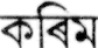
কৰিম
